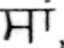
ਸਾਂ,
